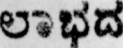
ಲಾಭದ
